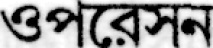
ওপরেসন
